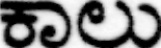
ಕಾಲು
